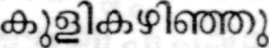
കുളികഴിഞ്ഞു
